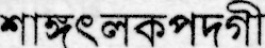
শাঙ্গৎলকপদগী
